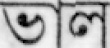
ভাল
